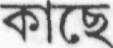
কাছে
